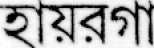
হায়রগা
